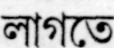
লাগতে
